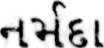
નર્મદા
